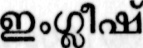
ഇംഗ്ലീഷ്
